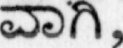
ವಾಗಿ,
